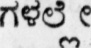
ಗಳಲ್ಲೇ
